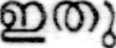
ഇതു
